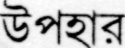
উপহার
